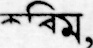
কৰিম,
